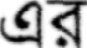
এর
